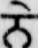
ਨੇ
